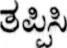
ತಪ್ಪಿಸಿ
